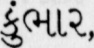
કુંભાર,
